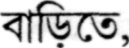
বাড়িতে,
